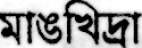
মাঙখিদ্রা
